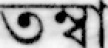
তম্বা
